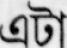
এটা
